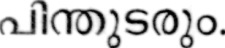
പിന്തുടരും.
